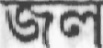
জল
